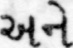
અને
